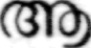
ആ
